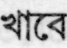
খাবে
